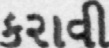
કરાવી
